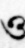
ও
